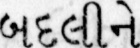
બદલીને
